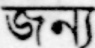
জন্য
